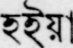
হইয়া
